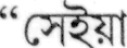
"সেইয়া
